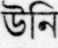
উনি
